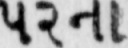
પરના
